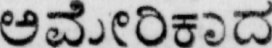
ಅಮೇರಿಕಾದ
